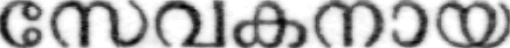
സേവകനായ
